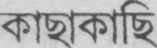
কাছাকাছি
